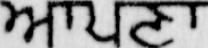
ਆਪਣਾ
